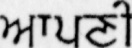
ਆਪਣੀ
